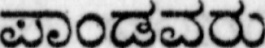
ಪಾಂಡವರು
